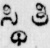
ಸ್ಥಿತಿ
